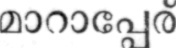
മാറാപ്പേര്
